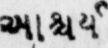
આશ્ચર્ય
